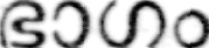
ഭാഗം
